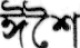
ঈশৈ
